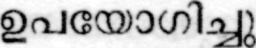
ഉപയോഗിച്ചു
